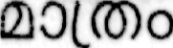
മാത്രം
